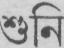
শুনি
